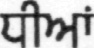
ਧੀਆਂ
